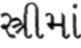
સ્રીમાં
